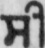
ਸੀ
